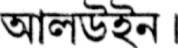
আলউইন।
